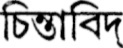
চিন্তাবিদ্
